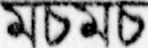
মচমচ
